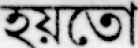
হয়তো
